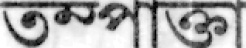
তম্পাক্তা
